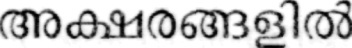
അക്ഷരങ്ങളില്‍
